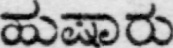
ಹುಷಾರು
